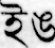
ইঙ
